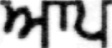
ਆਪ
